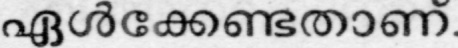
ഏള്‍ക്കേണ്ടതാണ്.
